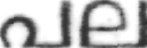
പല
